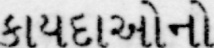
કાયદાઓનો
